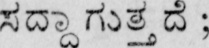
ಸದ್ದಾಗುತ್ತದೆ;
